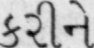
કરીને
